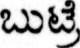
ಬುಟ್ರೆ
